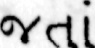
જતાં
